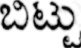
ಬಿಟ್ಟು
